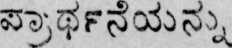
ಪ್ರಾರ್ಥನೆಯನ್ನು
